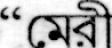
“মেরী
